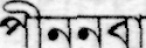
পীননবা
